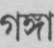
গঙ্গা
